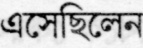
এসেছিলেন
